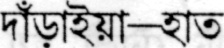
দাঁড়াইয়া—হাত
